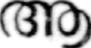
ആ
